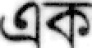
এক
